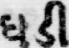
ઘડી
